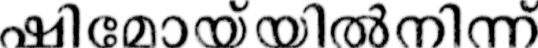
ഷിമോയ്യില്‍നിന്ന്
